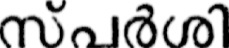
സ്പര്‍ശി
